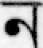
ন
